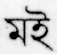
মই
